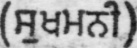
(ਸੁਖਮਨੀ)
